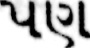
પણ
